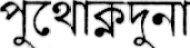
পুথোক্নদুনা
